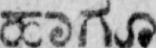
ಹಾಗೂ
